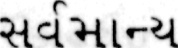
સર્વમાન્ય
